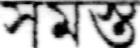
সমস্ত
